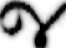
જ
